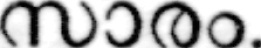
സാരം.
